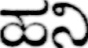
ಹನಿ
